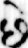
છે
